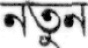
নতুন
